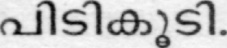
പിടികൂടി.
